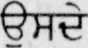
ਉਸਦੇ
